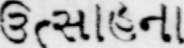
ઉત્સાહના
